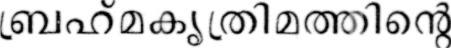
ബ്രഹ്മകൃത്രിമത്തിന്റെ
